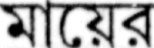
মায়ের
